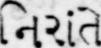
નિરાંતિ
